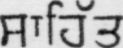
ਸਾਹਿੱਤ
